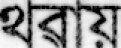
থৱায়
